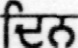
ਦਿਨ
